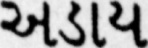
અડાય
